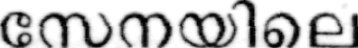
സേനയിലെ
